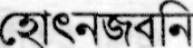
হোৎনজবনি
